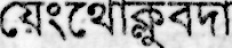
য়েংথোক্লুবদা
